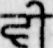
ਵੀ
